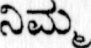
ನಿಮ್ಮ
